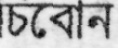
চিবোন
